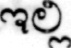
ಇಲ್ಲಿ
